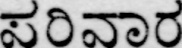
ಪರಿವಾರ
